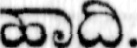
ಹಾದಿ.
